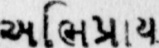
અભિપ્રાય
